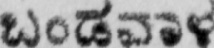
ಬಂಡವಾಳ
